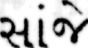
સાંજે
